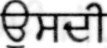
ਉਸਦੀ
